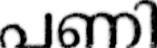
പണി
